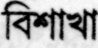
বিশাখা
